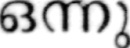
ഒന്നു
